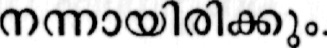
നന്നായിരിക്കും.
